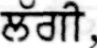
ਲੱਗੀ,
